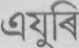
এযুৰি
